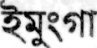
ইমুংগা
